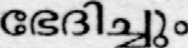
ഭേദിച്ചും
